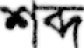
শব্দ
